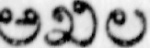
ಅಖಿಲ
